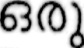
ഒരു
